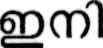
ഇനി
